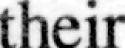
their
